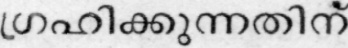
ഗ്രഹിക്കുന്നതിന്
